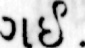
ગઈ.
